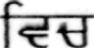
ਵਿਚ
